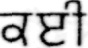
ਕਈ
